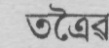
তত্ৰৈৱ
